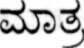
ಮಾತ್ರ
